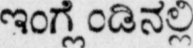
ಇಂಗ್ಲೆಂಡಿನಲ್ಲಿ
